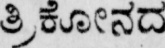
ತ್ರಿಕೋನದ
